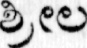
ಶ್ರೀಲ
